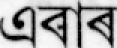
এবাৰ
